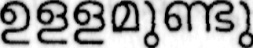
ഉള്ളമുണ്ടു
